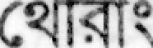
থৌরাং
